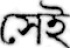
সেই
